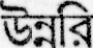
উন্নরি
